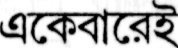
একেবারেই
